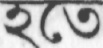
হতে
